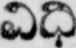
ವಿಧಿ
